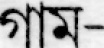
গাম-
